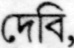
দেবি,
